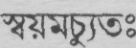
স্বয়মচ্যুতঃ
